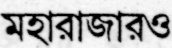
মহারাজারও
